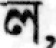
ল,
